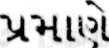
પ્રમાણે
